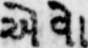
એવો
